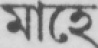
মাহে
